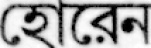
হোরেন
